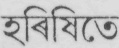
হৰিষিতে
